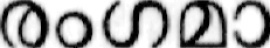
രംഗമാ
